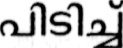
പിടിച്ച്
